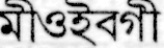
মীওইবগী
